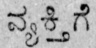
ವ್ಯಕ್ತಿಗೆ
